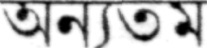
অন্যতম
